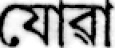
যোৱা
